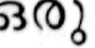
ഒരു
